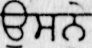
ਉਸਨੇ
